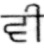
ਵੀ
